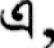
এ,
